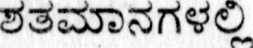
ಶತಮಾನಗಳಲ್ಲಿ
